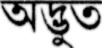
অদ্ভুত
